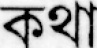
কথা
